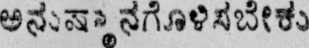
ಅನುಷ್ಠಾನಗೊಳಿಸಬೇಕು
